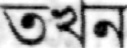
তখন
